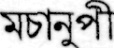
মচানুপী
